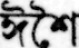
ঈশৈ
